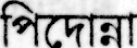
পিদোন্না
